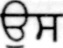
ਉਸ
